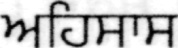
ਅਹਿਸਾਸ
